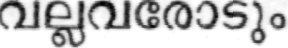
വല്ലവരോടും
